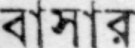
বাসার
